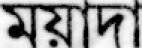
ময়াদা
